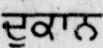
ਦੁਕਾਨ
